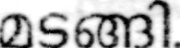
മടങ്ങി.
